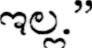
ಇಲ್ಲ."
